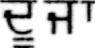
ਦੂਜਾ
